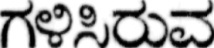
ಗಳಿಸಿರುವ
